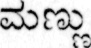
ಮಣ್ಣು
